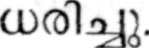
ധരിച്ചു.
